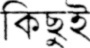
কিছুই
